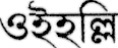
ওইহল্লি
